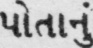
પોતાનું
